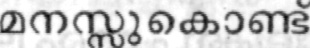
മനസ്സുകൊണ്ട്
